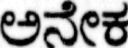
ಅನೇಕ
